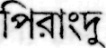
পিরাংদু
